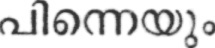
പിന്നെയും
